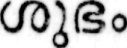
ശുഭം
